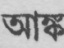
আঙ্ক
